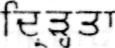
ਦ੍ਰਿੜ੍ਹਤਾ
